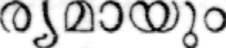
ര്യമായും
